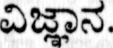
ವಿಜ್ಞಾನ.
